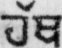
ਹੱਥ
